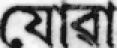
যোৱা
